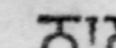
ਨਾਲ
